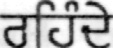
ਰਹਿੰਦੇ
